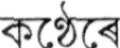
কণ্ঠেৰে
